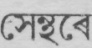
সেন্থৰে
